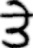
ਤੇ
